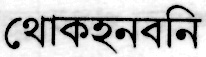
থোকহনবনি
